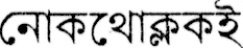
নোকথোক্লকই
